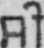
ਸੀ
